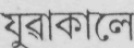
যুৱাকালে
